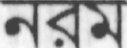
নরম
